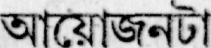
আয়োজনটা
